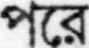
পরে
